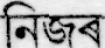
নিজৰ
